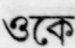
ওকে
